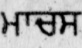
ਮਾਚਸ
